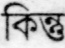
কিন্তু
